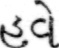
હવે
